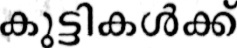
കുട്ടികള്‍ക്ക്
